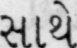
સાથે
